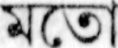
মতো
